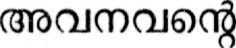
അവനവന്റെ
